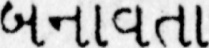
બનાવતા
